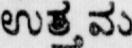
ಉತ್ತಮ
